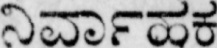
ನಿರ್ವಾಹಕ
